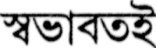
স্বভাবতই
